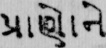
પ્રાણોને
